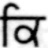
ਕਿ
